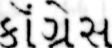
કોંગ્રેસ
